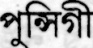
পুন্সিগী
